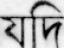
যদি
